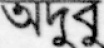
অদুবু
